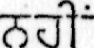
ਨਹੀਂ
